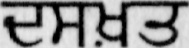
ਦਸਖ਼ਤ
